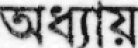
অধ্যায়
